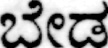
ಬೇಡ
